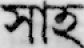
সাহ
